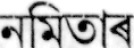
নমিতাৰ
